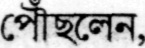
পৌঁছলেন,
